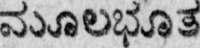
ಮೂಲಭೂತ
